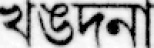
খঙদনা
